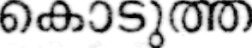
കൊടുത്ത
